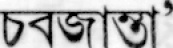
চবজান্তা'
